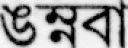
ঙম্নবা
